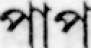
পাপ
